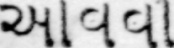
આવવા
